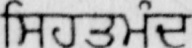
ਸਿਹਤਮੰਦ
